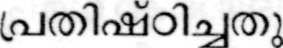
പ്രതിഷ്ഠിച്ചതു
